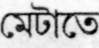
মেটাতে
